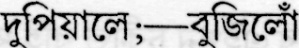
দুপিয়ালে;-বুজিলোঁ
